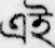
এই
